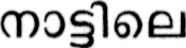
നാട്ടിലെ
